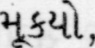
મૂક્યો,
